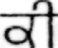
ਕੀ
